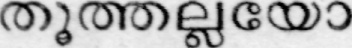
തൂത്തല്ലയോ
